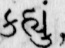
કહ્યું,
